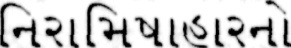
નિરામિષાહારનો
